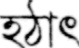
হঠাত্
